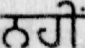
ਨਹੀਂ
